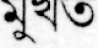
মুখত
